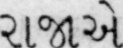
રાજાએ
